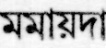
মমায়দা
